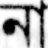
না
